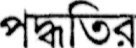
পদ্ধতির
